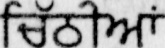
ਚਿੱਠੀਆਂ
